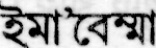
ইমা’বেম্মা
